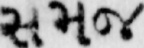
સમજ
